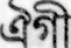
ঐগী
